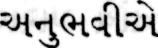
અનુભવીએ
